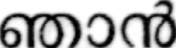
ഞാന്‍
